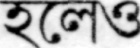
হলেও
